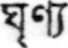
ঘৃণ্য
